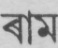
ৰাম
